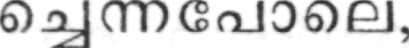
ച്ചെന്നപോലെ,
